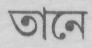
তানে
